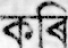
কৰি
